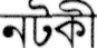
নটকী
